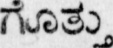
ಗೊತ್ತು
